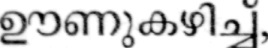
ഊണുകഴിച്ച്,
